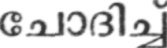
ചോദിച്ച്
